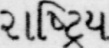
રાષ્ટ્રિય
